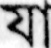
যা
